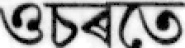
ওচৰতে
